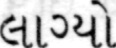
લાગ્યો
